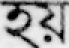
হয়
